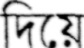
দিয়ে
